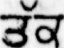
ਤੱਕ
